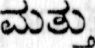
ಮತ್ತು
